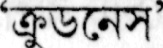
‘ক্রুডনেস’
